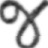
જ
